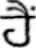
ਹੈਂ
